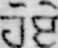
ਹੋਏ
